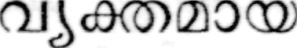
വ്യക്തമായ
